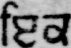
ਇਕ
